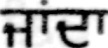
ਜਾਂਦਾ
